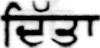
ਦਿੱਤਾ
